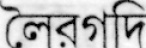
লৈরগদি
